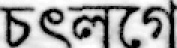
চৎলগে
